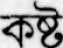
কষ্ট
